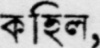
কহিল,
